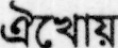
ঐখোয়
